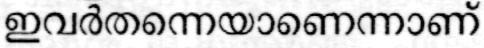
ഇവര്‍തന്നെയാണെന്നാണ്
